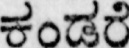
ಕಂಡರೆ
